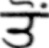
ਤੋਂ
